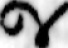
જ
